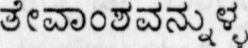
ತೇವಾಂಶವನ್ನುಳ್ಳ
